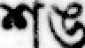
শঙ
